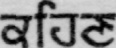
ਕਹਿਣ
